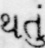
થતું
